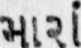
મારાં
